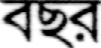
বছর
